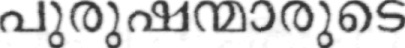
പുരുഷന്മാരുടെ
